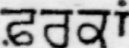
ਫ਼ਰਕਾਂ
